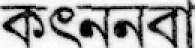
কৎননবা
